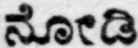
ನೋಡಿ
